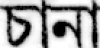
চানা
